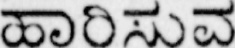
ಹಾರಿಸುವ
